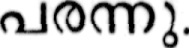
പരന്നു.
